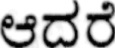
ಆದರೆ
